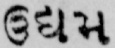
ઉદ્યમ
